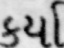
કર્યા
